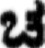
ಚ
